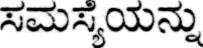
ಸಮಸ್ಯೆಯನ್ನು
